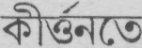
কীৰ্ত্তনতে
